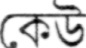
কেউ
